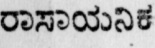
ರಾಸಾಯನಿಕ
